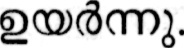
ഉയര്‍ന്നു.
